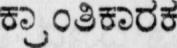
ಕ್ರಾಂತಿಕಾರಕ
